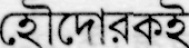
হৌদোরকই
